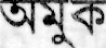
অমুক
